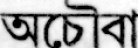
অচৌবা
